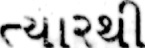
ત્યારથી
